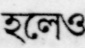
হলেও
